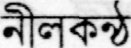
নীলকন্ঠ
